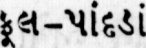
ફૂલ-પાંદડાં
